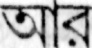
আর
